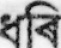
ধৰি
